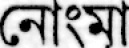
নোংমা
